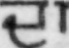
ਦਾ
